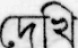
দেখি
